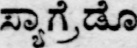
ಸ್ಯಾಗ್ರೆಡೊ
